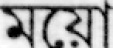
ময়ো
